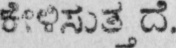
ಕೇಳಿಸುತ್ತದೆ.
